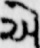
એ
